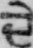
ਦੇ
